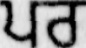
ਪਰ
